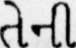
તેની
